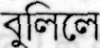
বুলিলে
